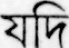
যদি
